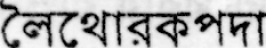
লৈথোরকপদা
